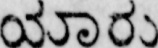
ಯಾರು
